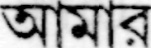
আমার
